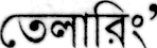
তেলারিং’
